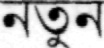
নতুন
